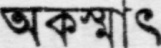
অকস্মাৎ
